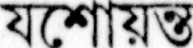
যশোয়ন্ত
